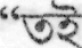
"তই
